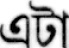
এটা
